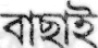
বাছাই
